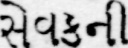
સેવકની
